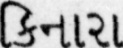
કિનારા
